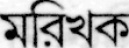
মরিখক
